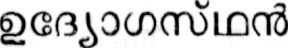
ഉദ്യോഗസ്ഥന്‍
